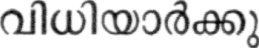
വിധിയാര്‍ക്കു
